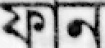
ফান
